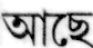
আছে
